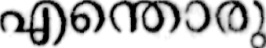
എന്തൊരു
